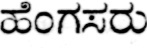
ಹೆಂಗಸರು
